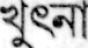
খুৎনা
